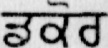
ਡਕੋਰ
